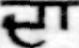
ਦਾ
